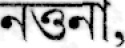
নত্তনা,
